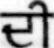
ਦੀ
